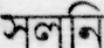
সলনি
